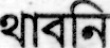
থাবনি
